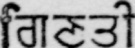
ਗਿਣਤੀ
